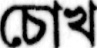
চোখ
